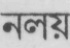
নলয়
